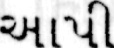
આપી
